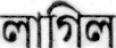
লাগিল
